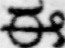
ಈ
